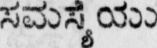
ಸಮಸ್ಯೆಯು
